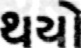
થયો
